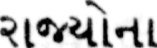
રાજ્યોના
